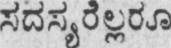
ಸದಸ್ಯರೆಲ್ಲರೂ
